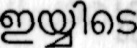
ഇയ്യിടെ
